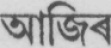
আজিৰ
